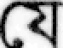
যে
